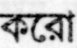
করো
